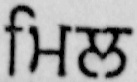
ਮਿਲ
